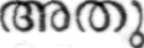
അതു
